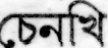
চেনখি
